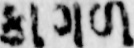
કાગળ
